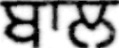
ਬਾਲ
